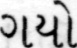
ગયો
